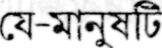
যে-মানুষটি
